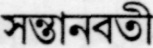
সন্তানবতী
